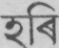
হৰি
